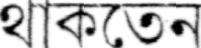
থাকতেন
